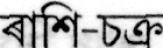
ৰাশি-চক্র
